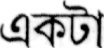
একটা
